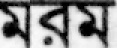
মরম
